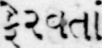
ફેરવતાં
